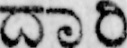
ದಾರಿ
